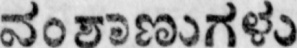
ವಂಶಾಣುಗಳು
